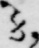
કે,
